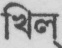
খিল্
